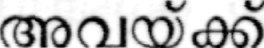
അവയ്ക്ക്
